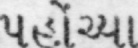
પહોંચ્યા
